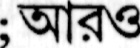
;আরও
